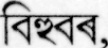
বিহুবৰ,
